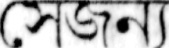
সেজন্য
